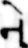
ને
